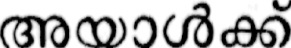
അയാള്‍ക്ക്
